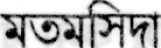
মতমসিদা
